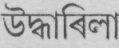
উদ্ধাৰিলা
